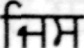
ਜਿਸ
